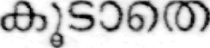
കൂടാതെ
